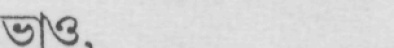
ভাও,
